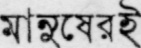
মানুষেরই
